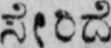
ಸೇರಿದೆ
